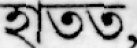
হাতত,
